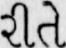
રીતે
